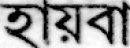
হায়বা
